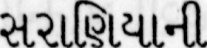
સરાણિયાની
